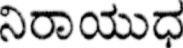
ನಿರಾಯುಧ
